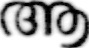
ആ
